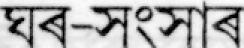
ঘৰ-সংসাৰ
